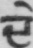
ਦੇ
